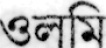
ওলমি
